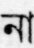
না
